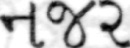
નજર
